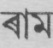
ৰাম
